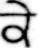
ਕੇ
